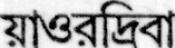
য়াওরদ্রিবা
